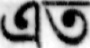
এত
